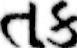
તક
